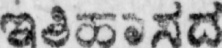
ಇತಿಹಾಸದ
